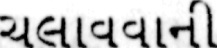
ચલાવવાની
